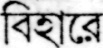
বিহারে
